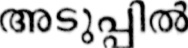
അടുപ്പില്‍
